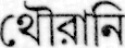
থৌরানি
